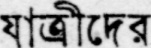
যাত্রীদের
